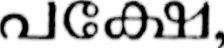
പക്ഷേ,
